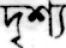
দৃশ্য
